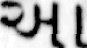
આ
